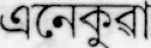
এনেকুৱা
